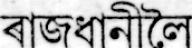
ৰাজধানীলৈ
